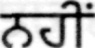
ਨਹੀਂ
